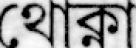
থোক্না
